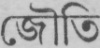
জৌতি
